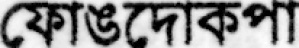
ফোঙদোকপা
